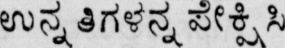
ಉನ್ನತಿಗಳನ್ನಪೇಕ್ಷಿಸಿ
